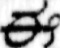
ಈ
